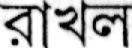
রাখল
